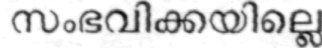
സംഭവിക്കയില്ലെ
